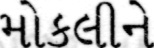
મોકલીને
